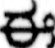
ಈ
